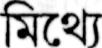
মিথ্যে
